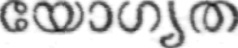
യോഗ്യത
